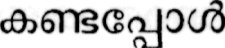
കണ്ടപ്പോള്‍
